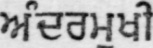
ਅੰਦਰਮੁਖੀ
